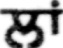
ਲਾਂ
